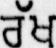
ਰੱਖ
